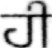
ਹੀ
